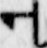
ન
